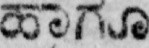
ಹಾಗೂ
